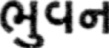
ભુવન
